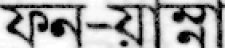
ফন-য়াম্না
